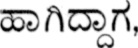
ಹಾಗಿದ್ದಾಗ,
